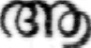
ആ
